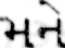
મને
